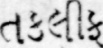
તકલીફ
